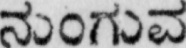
ನುಂಗುವ
